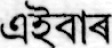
এইবাৰ
